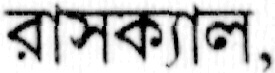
রাসক্যাল,
